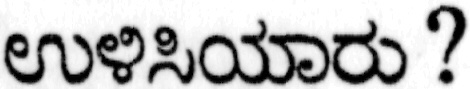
ಉಳಿಸಿಯಾರು?
